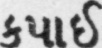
કપાઈ
